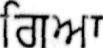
ਗਿਆ
